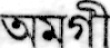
অমগী
